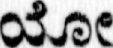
ಯೋ
